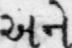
અને
